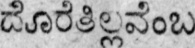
ದೊರೆತಿಲ್ಲವೆಂಬ
